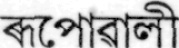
ৰূপোৱালী
